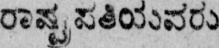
ರಾಷ್ಟ್ರಪತಿಯವರು
